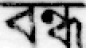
বন্ধ
